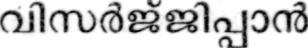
വിസര്‍ജ്ജിപ്പാന്‍
